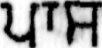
ਪਾਸ
